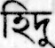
হিদু
